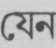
যেন
